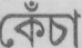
কেঁচা
